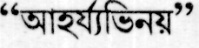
“আহর্য্যভিনয়”
